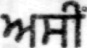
ਅਸੀਂ
